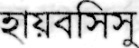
হায়বসিসু
